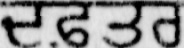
ਦਫ਼ਤਰ
